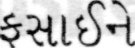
ફસાઈને
